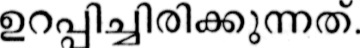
ഉറപ്പിച്ചിരിക്കുന്നത്.
